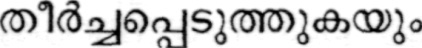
തീര്‍ച്ചപ്പെടുത്തുകയും
